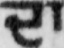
ਦਾ
